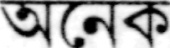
অনেক
